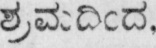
ಶ್ರಮದಿಂದ,
